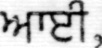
ਆਈ,
